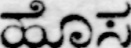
ಹೊಸ
